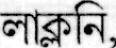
লাক্লনি,
